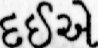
દઈએ
